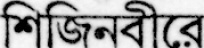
শিজিনবীরে
